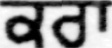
ਕਰਾ
